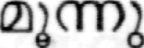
മൂന്നു
